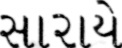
સારાયે
